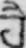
ਹੈ
